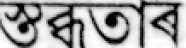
স্তব্ধতাৰ
